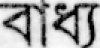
বাধ্য
